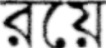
রয়ে
